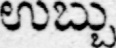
ಉಬ್ಬು
